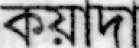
কয়াদা
